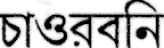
চাওরবনি
